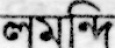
লমন্দি
